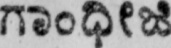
ಗಾಂಧೀಜಿ
